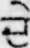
ਦੇ
